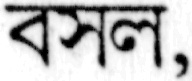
বসল,
